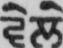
ਵੇਲੇ
